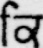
ਕਿ
